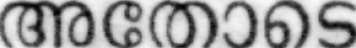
അതോടെ
